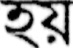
হয়
